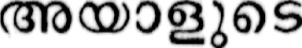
അയാളുടെ
